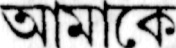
আমাকে
